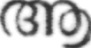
ആ
